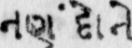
નણંદોને
